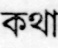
কথা
